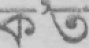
ক'ত
